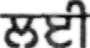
ਲਈ
